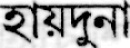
হায়দুনা
